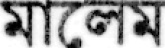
মালেম
